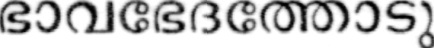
ഭാവഭേദത്തോടു
